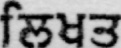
ਲਿਖਤ
